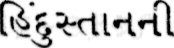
હિંદુસ્તાનની
